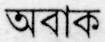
অবাক
